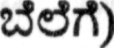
ಬೆಲೆಗೆ)
